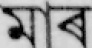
মাৰ
